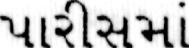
પારીસમાં
